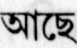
আছে
